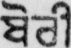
ਬੋਰੀ
